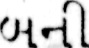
બની
